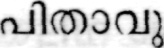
പിതാവു
